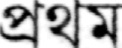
প্রথম
